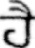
ਹੈ
